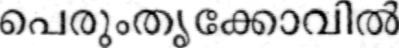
പെരുംതൃക്കോവില്‍
